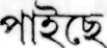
পাইছে
